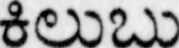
ಕಿಲುಬು
